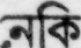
নেকি
